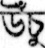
উঁচু
